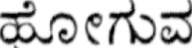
ಹೋಗುವ
